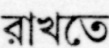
রাখতে
